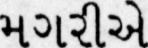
મગરીએ
